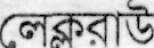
লেক্লরাউ
